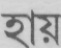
হায়
